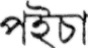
পইচা
